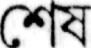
শেষ
